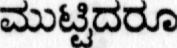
ಮುಟ್ಟಿದರೂ
